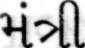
મંત્રી
